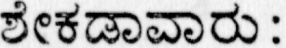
ಶೇಕಡಾವಾರು:
